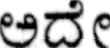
ಅದೇ
